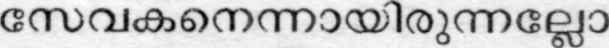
സേവകനെന്നായിരുന്നല്ലോ
